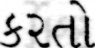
કરતો
